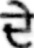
ਦੇ
